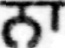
ਨਾ
